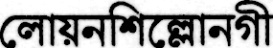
লোয়নশিল্লোনগী
